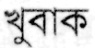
খুবাক
